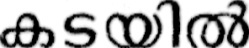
കടയില്‍
